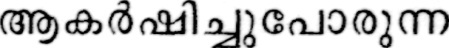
ആകര്‍ഷിച്ചുപോരുന്ന
